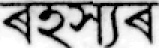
ৰহস্যৰ
